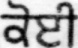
ਕੋਈ
